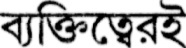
ব্যক্তিত্বেরই
